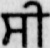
ਸੀ
